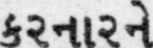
કરનારને
